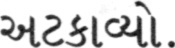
અટકાવ્યો.
